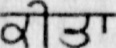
ਕੀਤਾ
